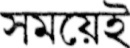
সময়েই
